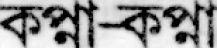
কপ্না-কপ্না
